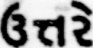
ઉત્તરે
